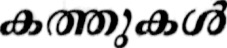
കത്തുകള്‍
